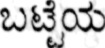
ಬಟ್ಟೆಯ
